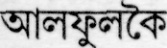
আলফুলকৈ
